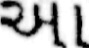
આ
